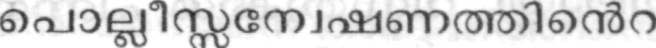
പൊല്ലീസ്സന്വേഷണത്തിന്റെ
